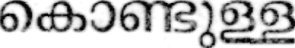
കൊണ്ടുള്ള
